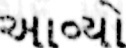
આવ્યો
